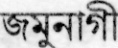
জমুনাগী
